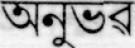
অনুভৱ
